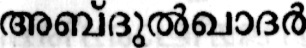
അബ്ദുല്‍ഖാദര്‍
